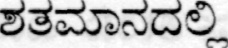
ಶತಮಾನದಲ್ಲಿ
